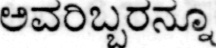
ಅವರಿಬ್ಬರನ್ನೂ
